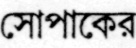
সোপাকের
